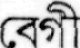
বেগী
